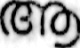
ആ
